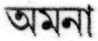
অমনা
